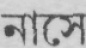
নাসে
